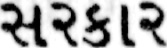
સરકાર
